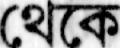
থেকে
